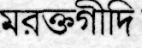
মরক্তগীদি
